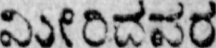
ಮೀರಿದವರ
